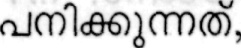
പനിക്കുന്നത്,
